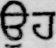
ਉਹ
